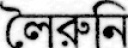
লৈরুনি
